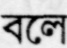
বলে
